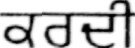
ਕਰਦੀ
